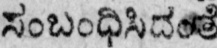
ಸಂಬಂಧಿಸಿದಂತೆ
